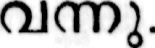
വന്നു.
